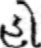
હો
